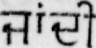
ਜਾਂਦੀ
